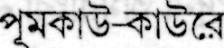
পুমকাউ-কাউরে
